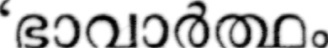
'ഭാവാര്‍ത്ഥം
